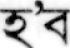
হ'ব
